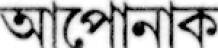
আপোনাক
